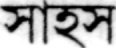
সাহস
